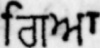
ਗਿਆ
